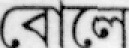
বোলে
